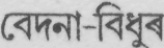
বেদনা-বিধুৰ
